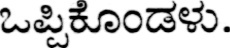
ಒಪ್ಪಿಕೊಂಡಳು.
